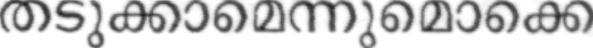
തടുക്കാമെന്നുമൊക്കെ
